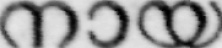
നായ
